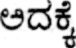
ಅದಕ್ಕೆ
